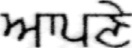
ਆਪਣੇ
